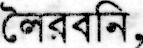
লৈরবনি,
